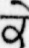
ਕੇ
